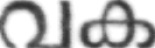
വക
